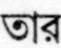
তার
